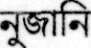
নুজানি
